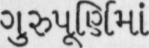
ગુરુપૂર્ણિમાં
